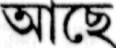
আছে
